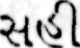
સહી
